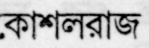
কোশলরাজ
